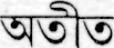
অতীত
